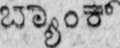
ಬ್ಯಾಂಕ್
